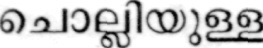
ചൊല്ലിയുള്ള
